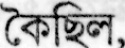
কৈছিল,
